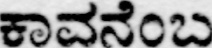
ಕಾವನೆಂಬ
